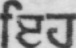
ਇਹ
